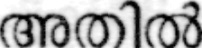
അതില്‍
